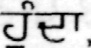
ਹੁੰਦਾ,
